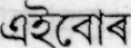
এইবোৰ
